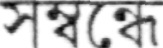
সম্বন্ধে
